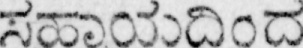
ಸಹಾಯದಿಂದ
